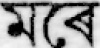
মৰে
